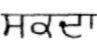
ਸਕਦਾ
